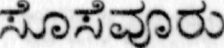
ಸೊಸೆವೂರು
